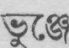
ভুঞ্জে
